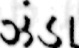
ઝંડા
